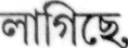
লাগিছে,
